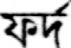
ফর্দ
